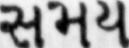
સમય
